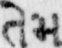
તેમ
